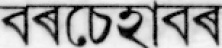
বৰচেহাবৰ
